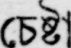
চেষ্টা
